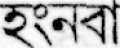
হংনবা
